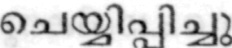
ചെയ്യിപ്പിച്ചു
